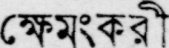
ক্ষেমংকরী
